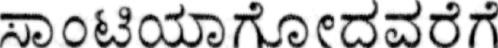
ಸಾಂಟಿಯಾಗೋದವರೆಗೆ
